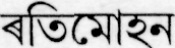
ৰতিমোহন
